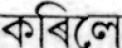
কৰিলে
